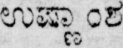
ಉಷ್ಣಾಂಶ
